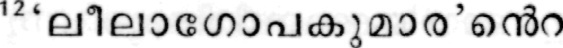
12'ലീലാഗോപകുമാര'ന്റെ
